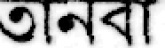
তানবা
